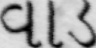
વાડ
